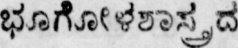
ಭೂಗೋಳಶಾಸ್ತ್ರದ
